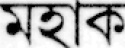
মহাক
